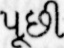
પૂછી
